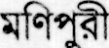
মণিপুরী
